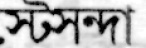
স্টেসন্দা
